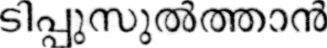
ടിപ്പുസുല്‍ത്താന്‍
